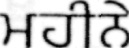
ਮਹੀਨੇ
